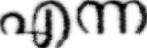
എന്ന
